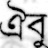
ঐবু
